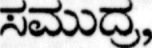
ಸಮುದ್ರ,
